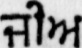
ਜੀਅ
